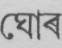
ঘোৰ
